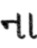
ના
